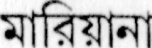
মারিয়ানা
